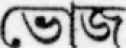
ভোজ
